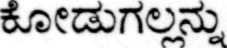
ಕೋಡುಗಲ್ಲನ್ನು
